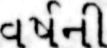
વર્ષની
